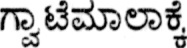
ಗ್ವಾಟೆಮಾಲಾಕ್ಕೆ
